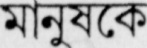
মানুষকে
